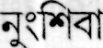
নুংশিবা
